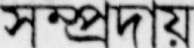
সম্প্রদায়
